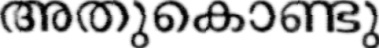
അതുകൊണ്ടു
